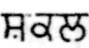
ਸ਼ਕਲ
